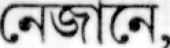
নেজানে,
